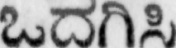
ಒದಗಿಸಿ
